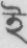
ই
